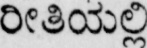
ರೀತಿಯಲ್ಲಿ
